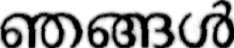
ഞങ്ങള്‍
